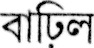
বাঢ়িল
